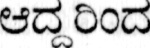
ಆದ್ದರಿಂದ
